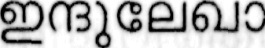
ഇന്ദുലേഖാ
